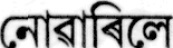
নোৱাৰিলে
